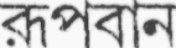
রূপবান
